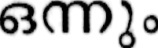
ഒന്നും
